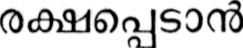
രക്ഷപ്പെടാന്‍
